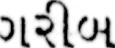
ગરીબ
